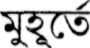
মুহূর্তে
